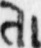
તો
